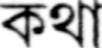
কথা
